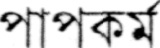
পাপকর্ম
